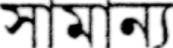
সামান্য
